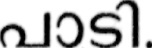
പാടി.
